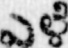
ಎಳೆ
